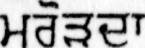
ਮਰੋੜਦਾ
